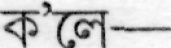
ক'লে-
